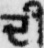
ਦੀ
